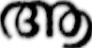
ആ
